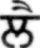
ਲੈ
